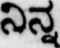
ನಿನ್ನ
